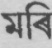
মৰি
